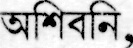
অশিবনি,
